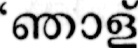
‘ഞാള്
